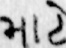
માટે
